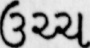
ઉચ્ચ
